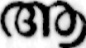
ആ
